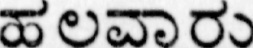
ಹಲವಾರು
